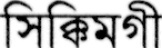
সিক্কিমগী
